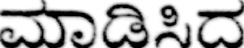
ಮಾಡಿಸಿದ
